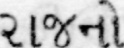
રાજનો
